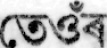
তেওঁৰ
